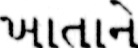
ખાતાને
